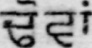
ਢੋਵਾਂ
